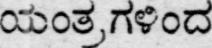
ಯಂತ್ರಗಳಿಂದ
